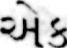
એક
